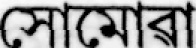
সোমোৱা
